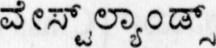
ವೇಸ್ಟ್‌ಲ್ಯಾಂಡ್ಸ್
